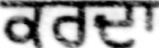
ਕਰਦਾ
